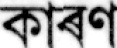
কাৰণ
